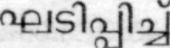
ഘടിപ്പിച്ച്
